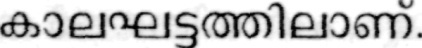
കാലഘട്ടത്തിലാണ്.
